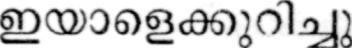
ഇയാളെക്കുറിച്ചു
